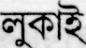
লুকাই
